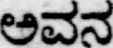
ಅವನ
